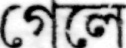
গেলে
